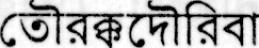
তৌরক্কদৌরিবা
